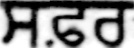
ਸਫ਼ਰ
